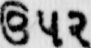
ઉપર
